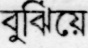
বুঝিয়ে
